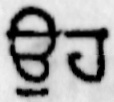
ਉਹ
